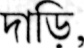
দাড়ি,
